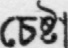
চেষ্টা
